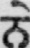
ਨੇ
